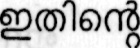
ഇതിന്റെ
